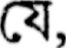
যে,
